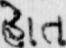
હોત
